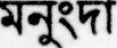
মনুংদা
